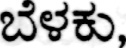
ಬೆಳಕು,
